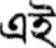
এই
